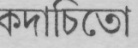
কদাচিতো
